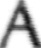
A
